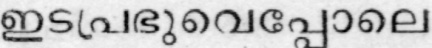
ഇടപ്രഭുവെപ്പോലെ
